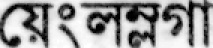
য়েংলম্লগা
